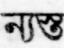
ন্যস্ত
